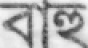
বাহু
